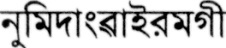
নুমিদাংৱাইরমগী
